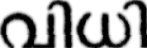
വിധി
